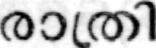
രാത്രി
